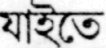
যাইতে
